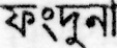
ফংদুনা
